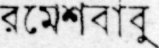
রমেশবাবু
